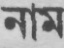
নাম
